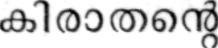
കിരാതന്റെ
